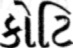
કોટિ
